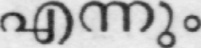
എന്നും
